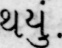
થયું.
